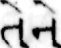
તેને
